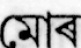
মোৰ
